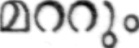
മററും
